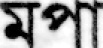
মপা
